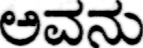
ಅವನು
